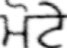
ਮੋਟੇ
